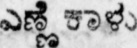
ಎಣ್ಣೆಕಾಳು
